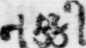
નક્કી
